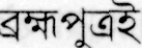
ব্রহ্মপুত্রই
